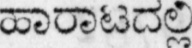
ಹಾರಾಟದಲ್ಲಿ
